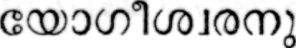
യോഗീശ്വരനു
